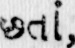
છતાં,
